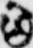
છે
